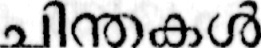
ചിന്തകള്‍
